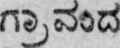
ಗ್ರಾಮದ
